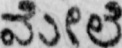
ಮೇಲೆ
